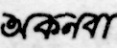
অকনবা
